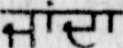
ਜਾਂਦਾ
